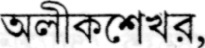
অলীকশেখর,
